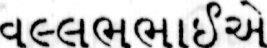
વલ્લભભાઈએ
